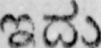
ಇದು
